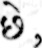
છે,
